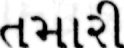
તમારી
